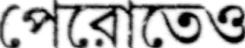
পেরোতেও
